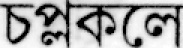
চপ্লকলে
